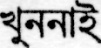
খূননাই
